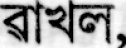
ৱাখল,
